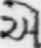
એ
